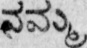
ನಮ್ಮ
